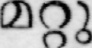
മറ്റു
